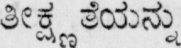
ತೀಕ್ಷ್ಣತೆಯನ್ನು
